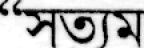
“সত্যম
